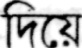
দিয়ে
